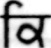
ਕਿ
